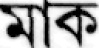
মাক
